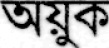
অয়ুক
